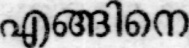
എങ്ങിനെ
